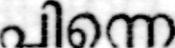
പിന്നെ
